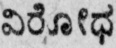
ವಿರೋಧ
